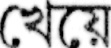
খেয়ে
